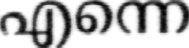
എന്നെ
